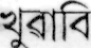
খুৱাবি
